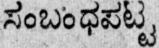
ಸಂಬಂಧಪಟ್ಟ
